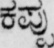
ಕಪ್ಪು
